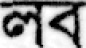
লব
